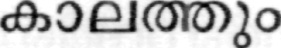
കാലത്തും
